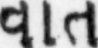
વાત
